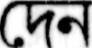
দেন
